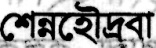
শেন্নহৌদ্রবা
